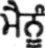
ਮੈਨੂੰ
